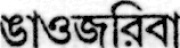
ঙাওজরিবা
